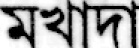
মখাদা
